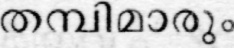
തമ്പിമാരും
